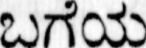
ಬಗೆಯ
